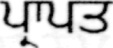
ਪ੍ਰਾਪਤ
